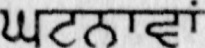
ਘਟਨਾਵਾਂ
